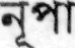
নূপা
